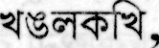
খঙলকখি,
